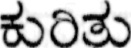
ಕುರಿತು
